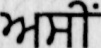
ਅਸੀਂ
